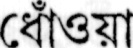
ধোঁওয়া
